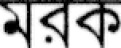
মরক
